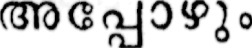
അപ്പോഴും
